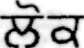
ਲੋਕ
